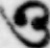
ও
